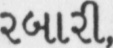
રબારી,
